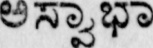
ಅಸ್ವಾಭಾ
